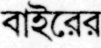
বাইরের
